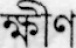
ক্ষীণ
